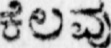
ಕೆಲವು
